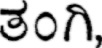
ತಂಗಿ,
